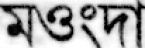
মওংদা
